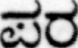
ಪರ
